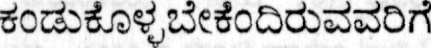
ಕಂಡುಕೊಳ್ಳಬೇಕೆಂದಿರುವವರಿಗೆ
